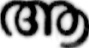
ആ
